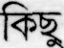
কিছু
